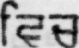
ਵਿਚ
